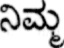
ನಿಮ್ಮ
